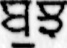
ਬੁਝ
